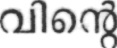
വിന്റെ
